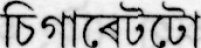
চিগাৰেটটো
